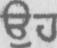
ਉਹ
